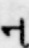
ન
